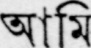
আমি
